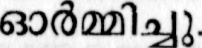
ഓര്‍മ്മിച്ചു.
